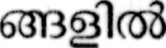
ങ്ങളില്‍
